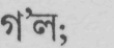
গ'ল;
